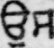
ਉਸ
